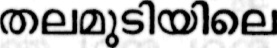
തലമുടിയിലെ
